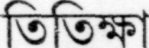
তিতিক্ষা
